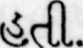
હતી.
